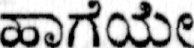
ಹಾಗೆಯೇ
